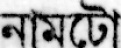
নামটো
